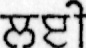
ਲਈ
